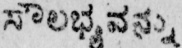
ಸೌಲಭ್ಯವನ್ನು
